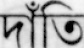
দাঁতি
